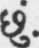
છું.
